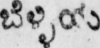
ಬೆಳ್ಳಿಯ
